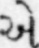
એ
